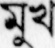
মুখ
